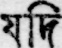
যদি
